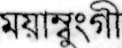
ময়াম্বুংগী
